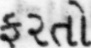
ફરતો
